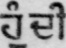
ਹੁੰਦੀ
